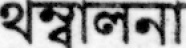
থম্বালনা
